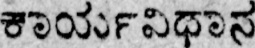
ಕಾರ್ಯವಿಧಾನ
